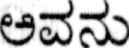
ಅವನು
